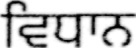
ਵਿਧਾਨ
